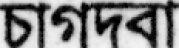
চাগদবা
